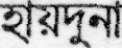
হায়দুনা
